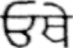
ਓਥੇ
